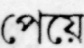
পেয়ে
